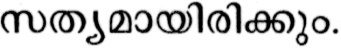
സത്യമായിരിക്കും.
